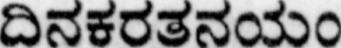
ದಿನಕರತನಯಂ
